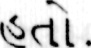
હતો.
